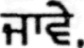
ਜਾਵੇ,
